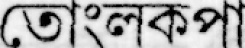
তোংলকপা
